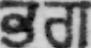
ਭਗ
